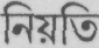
নিয়তি
